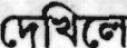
দেখিলে
